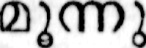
മൂന്നു
